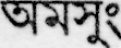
অমসুং
